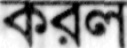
করল
